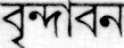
বৃন্দাবন
